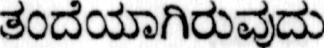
ತಂದೆಯಾಗಿರುವುದು
